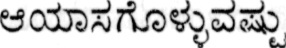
ಆಯಾಸಗೊಳ್ಳುವಷ್ಟು
